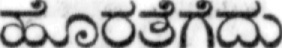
ಹೊರತೆಗೆದು
